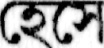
হেসে
